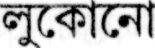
লুকোনো
